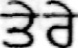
ਤੇਰੇ
